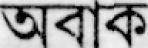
অবাক
